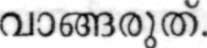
വാങ്ങരുത്.
